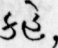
કહે,
